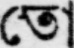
তো
